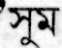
’সুম
